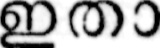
ഇതാ
